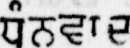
ਧੰਨਵਾਦ
